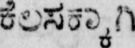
ಕೆಲಸಕ್ಕಾಗಿ
